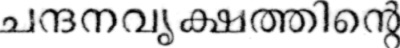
ചന്ദനവൃക്ഷത്തിന്റെ
